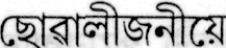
ছোৱালীজনীয়ে
